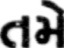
તમે
